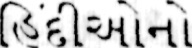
હિંદીઓનો
